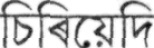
চিৰিয়েদি
